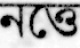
নত্তে
